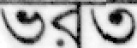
ভারত
